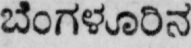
ಬೆಂಗಳೂರಿನ
